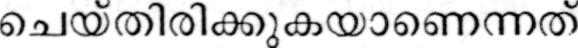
ചെയ്തിരിക്കുകയാണെന്നത്
